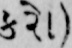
કરો)
